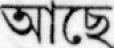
আছে
